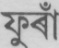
ফুৰাঁ
